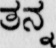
ತನ್ನ
